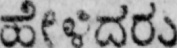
ಹೇಳಿದರು
